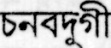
চনবদুগী
